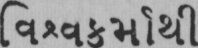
વિશ્વકર્માથી
